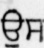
ਉਸ
